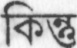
কিন্তু
